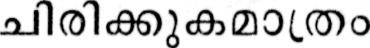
ചിരിക്കുകമാത്രം
